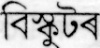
বিস্কুটৰ
